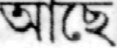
আছে
